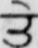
ਤੇ
